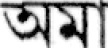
অমা
